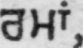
ਰਮਾਂ,
